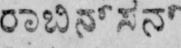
ರಾಬಿನ್ ಸನ್
